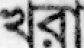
খরা
